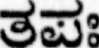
ತಪಃ
